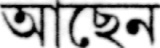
আছেন
